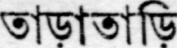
তাড়াতাড়ি
